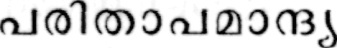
പരിതാപമാന്ദ്യ
